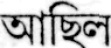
আছিল
